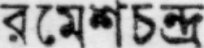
রমেশচন্দ্র
